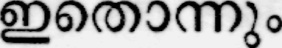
ഇതൊന്നും
